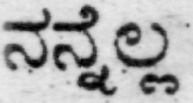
ಪಾಡು
